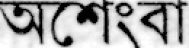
অশেংবা
